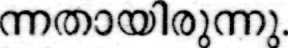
ന്നതായിരുന്നു.
